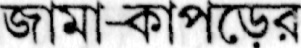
জামা-কাপড়ের
